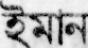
ইমান
